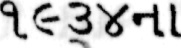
૧૯૩૪ના
